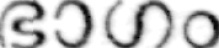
ഭാഗം
